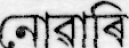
নোৱাৰি
